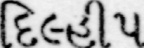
દિલ્હીપ
